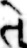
તે
